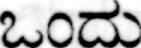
ಒಂದು
